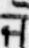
ਜੋ
